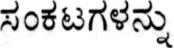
ಸಂಕಟಗಳನ್ನು
